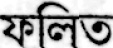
ফলিত
